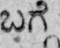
ಬಗ್ಗೆ
